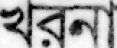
খরনা
